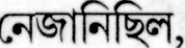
নেজানিছিল,
